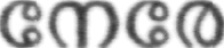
നേരേ
